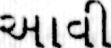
આવી
